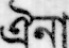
ঐনা
